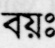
বয়ঃ
